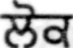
ਲੋਕ
